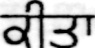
ਕੀਤਾ
